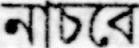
নাচবে
